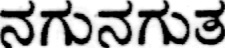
ನಗುನಗುತ
